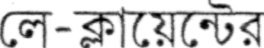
লে-ক্লায়েন্টের
